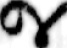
જ
